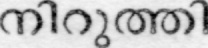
നിറുത്തി
